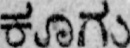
ಕೂಗು
